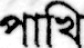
পাখি
